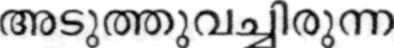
അടുത്തുവച്ചിരുന്ന
